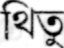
থিতু
